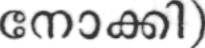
നോക്കി)
